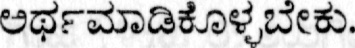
ಅರ್ಥಮಾಡಿಕೊಳ್ಳಬೇಕು.
